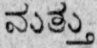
ಮತ್ತು
